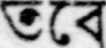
তবে
